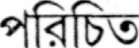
পরিচিত
